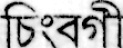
চিংবগী
